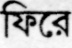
ফিরে
